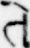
તે
